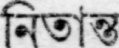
নিতান্ত
